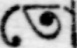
তো
